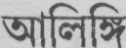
আলিঙ্গি
